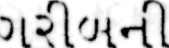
ગરીબની
